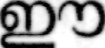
ഈ
